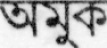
অমুক
